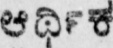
ಆರ್ಥಿಕ
